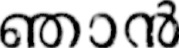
ഞാന്‍
